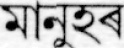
মানুহৰ
